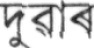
দুৱাৰ
